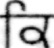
ਕਿ
